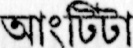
আংটিটা
